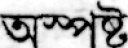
অস্পষ্ট
